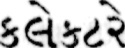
કલેક્ટરે
